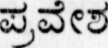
ಪ್ರವೇಶ
